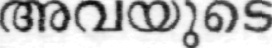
അവയുടെ
